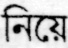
নিয়ে
